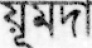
য়ূমদা
